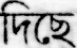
দিছে
